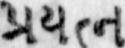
પ્રયત્ન
